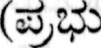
(ಪ್ರಭು
